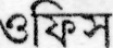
ওফিস
